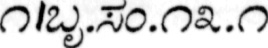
೧/ಬೃ.ಸಂ.೧೩.೧
